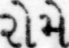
રોમે
